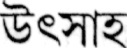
উত্সাহ
